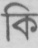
কি
